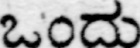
ಒಂದು
